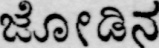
ಜೋಡಿನ
